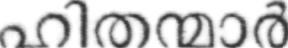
ഹിതന്മാര്‍
